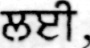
ਲਈ,
